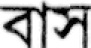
বাস
